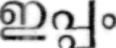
ഇപ്പം
